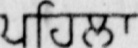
ਪਹਿਲਾ
